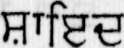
ਸ਼ਾਇਦ
